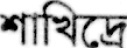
শাখিদ্রে
